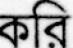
করি
